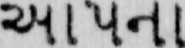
આપના
